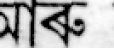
আৰু
